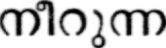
നീറുന്ന
